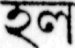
হল
